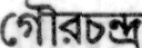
গৌরচন্দ্র
